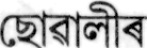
ছোৱালীৰ
